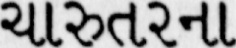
ચારુતરના
